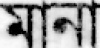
মানা
